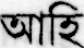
আহি
